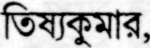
তিষ্যকুমার,
